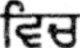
ਵਿਚ
